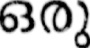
ഒരു
